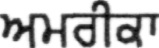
ਅਮਰੀਕਾ
